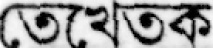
তেখেতক
